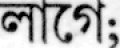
লাগে;
